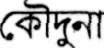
কৌদুনা
